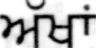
ਅੱਖਾਂ
